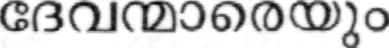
ദേവന്മാരെയും
